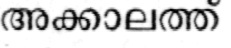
അക്കാലത്ത്.
